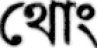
থোং
